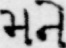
મને
